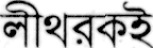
লীথরকই
